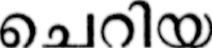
ചെറിയ
